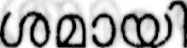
ശമായി
